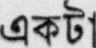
একটা
